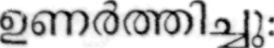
ഉണര്‍ത്തിച്ചു:
